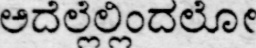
ಅದೆಲ್ಲೆಲ್ಲಿಂದಲೋ
